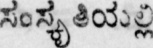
ಸಂಸ್ಕೃತಿಯಲ್ಲಿ
